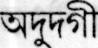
অদুদগী
